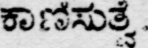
ಕಾಣಿಸುತ್ವೆ.
